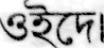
ওইদে।
